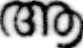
ആ
